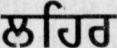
ਲਹਿਰ
